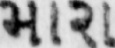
મારા
